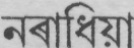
নৰাধিয়া
